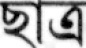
ছাত্র
